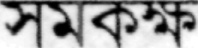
সমকক্ষ
